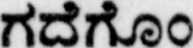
ಗದೆಗೊಂ
